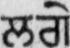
ਲਗੇ
